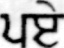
ਪਏ
